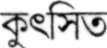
কুৎসিত
